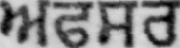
ਅਫਸਰ
